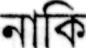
নাকি
